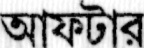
আফটার
